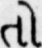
તો
